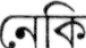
নেকি
